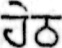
ਹੇਠ
